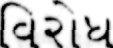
વિરોધ
